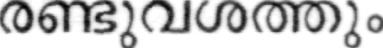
രണ്ടുവശത്തും
